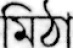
মিঠা
